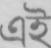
এই
